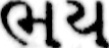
ભય
